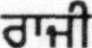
ਰਾਜੀ
